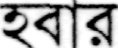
হবার
